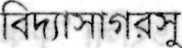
বিদ্যাসাগরসু
